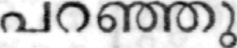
പറഞ്ഞു
